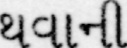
થવાની
